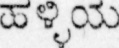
ಹಳ್ಳಿಯ
